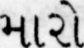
મારો
